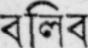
বলিব
